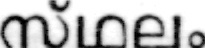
സ്ഥലം
